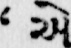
'એ
